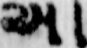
આ
